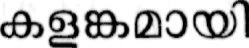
കളങ്കമായി
